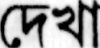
দেখা
